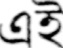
এই
